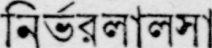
নির্ভরলালসা
